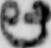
ಆ
